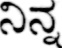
ನಿನ್ನ
